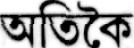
অতিকৈ
